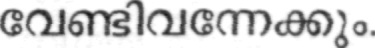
വേണ്ടിവന്നേക്കും.
